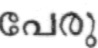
പേരു
